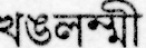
খঙলম্মী
